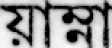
য়াম্না
